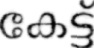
കേട്ട്
